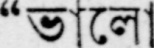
‘‘ভালো
